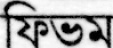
ফিভম
